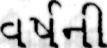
વર્ષની
